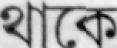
থাকে
